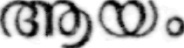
ആയം
